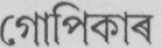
গোপিকাৰ
